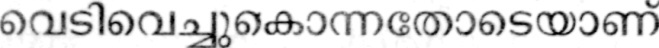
വെടിവെച്ചുകൊന്നതോടെയാണ്
